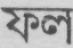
ফল
